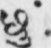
છું.
